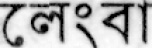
লেংবা
